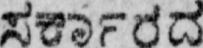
ಸರ್ಕಾರದ
